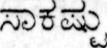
ಸಾಕಷ್ಟು
